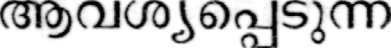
ആവശ്യപ്പെടുന്ന
